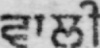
ਵਾਲੀ
